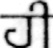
ਹੀ
